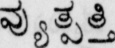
ವ್ಯುತ್ಪತ್ತಿ
